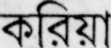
করিয়া
